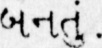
બનતું.
